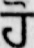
ਹੋ
